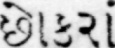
છોકરાં
